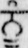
ਨੂੰ
